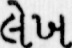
લેખ
